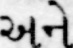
અને
